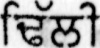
ਢਿੱਲੀ
